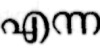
എന്ന
